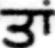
ਤਾਂ
